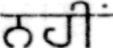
ਨਹੀਂ
